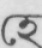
হে
